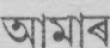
আমাৰ
